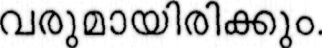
വരുമായിരിക്കും.
